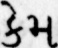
કેમ
